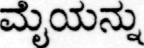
ಮೈಯನ್ನು
